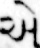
એ
